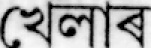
খেলাৰ
